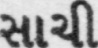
સાચી
